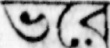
ভরে
